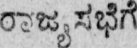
ರಾಜ್ಯಸಭೆಗೆ
